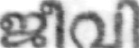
ജീവി
